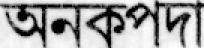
অনকপদা
